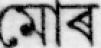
মোৰ
